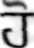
ਹੋ
